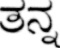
ತನ್ನ
